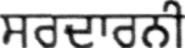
ਸਰਦਾਰਨੀ
